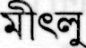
মীৎলু
